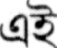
এই
